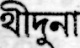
থীদুনা
